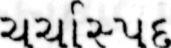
ચર્ચાસ્પદ
